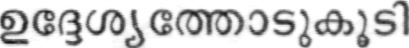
ഉദ്ദേശ്യത്തോടുകൂടി
